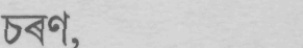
চৰণ,
